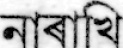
নাৰাখি
